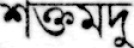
শক্তমদু
